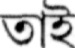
তাই
